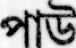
পাউ
